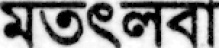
মতৎলবা
